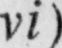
vi)
